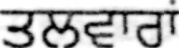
ਤਲਵਾਰਾਂ
